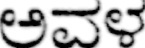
ಅವಳ
